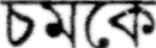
চমকে
